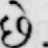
છે.
